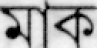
মাক
